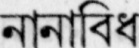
নানাবিধ
